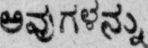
ಅವುಗಳನ್ನು
